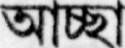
আচ্ছা
